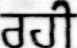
ਰਹੀ
